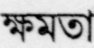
ক্ষমতা
